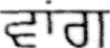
ਵਾਂਗ
